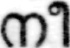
നീ
